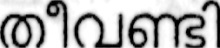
തീവണ്ടി
